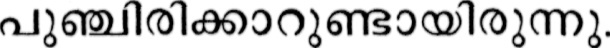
പുഞ്ചിരിക്കാറുണ്ടായിരുന്നു.
